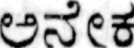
ಅನೇಕ
